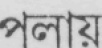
পলায়
